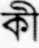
কী
